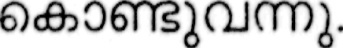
കൊണ്ടുവന്നു.
